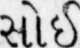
સોઈ
